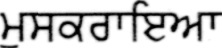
ਮੁਸਕਰਾਇਆ
